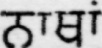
ਨਾਥਾਂ
